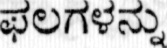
ಫಲಗಳನ್ನು
